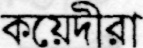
কয়েদীরা
